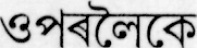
ওপৰলৈকে
